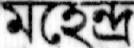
মহেন্দ্র
